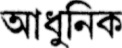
আধুনিক
